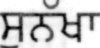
ਸੁਨੱਖਾ
